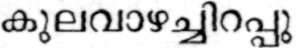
കുലവാഴച്ചിറപ്പു
